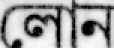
লোন
